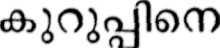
കുറുപ്പിനെ
